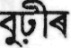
বুঢ়ীৰ
